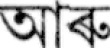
আৰু
